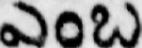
ಎಂಬ
